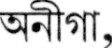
অনীগা,
